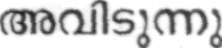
അവിടുന്നു
